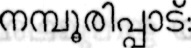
നമ്പൂരിപ്പാട്:
